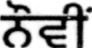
ਨੌਵੀਂ
